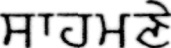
ਸਾਹਮਣੇ
